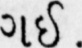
ગઈ.
